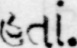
હતાં.
